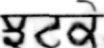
ਝਟਕੇ
